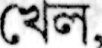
খেল,
